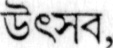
উৎসব,
